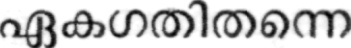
ഏകഗതിതന്നെ
